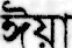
ঈয়া
